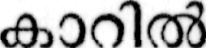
കാറില്‍
